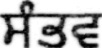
ਸੰਭਵ
